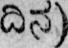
ದಿನ)
